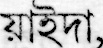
য়াইদা,
